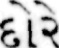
દોરે
